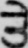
ਤੇ
